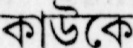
কাউকে
